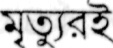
মৃত্যুরই
